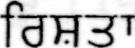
ਰਿਸ਼ਤਾ
